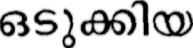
ഒടുക്കിയ
